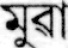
মুৱা
